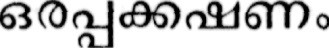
ഒരപ്പക്കഷണം
